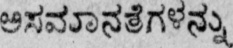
ಅಸಮಾನತೆಗಳನ್ನು
